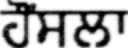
ਹੌਂਸਲਾ
